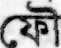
ফৌ
